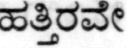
ಹತ್ತಿರವೇ
